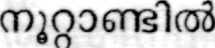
നൂറ്റാണ്ടില്‍
